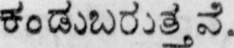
ಕಂಡುಬರುತ್ತವೆ.
